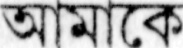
আমাকে
